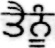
ਤੈਨੂੰ
